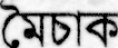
মৈচাক
